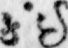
કંઈ
